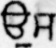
ਉਸ
